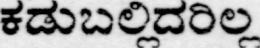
ಕಡುಬಲ್ಲಿದರಿಲ್ಲ
